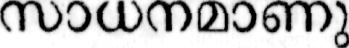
സാധനമാണു
